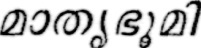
മാതൃഭൂമി
